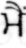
ਮੈਂ
